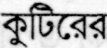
কুটিরের
